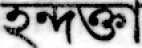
হন্দক্তা
